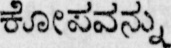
ಕೋಪವನ್ನು
